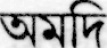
অমদি
